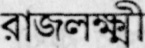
রাজলক্ষ্মী
